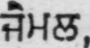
ਜੈਮਲ,
